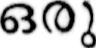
ഒരു
